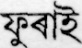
ফুৰাই
